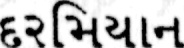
દરમિયાન
